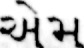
એમ
